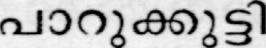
പാറുക്കുട്ടി
